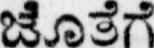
ಜೊತೆಗೆ
